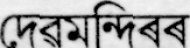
দেৱমন্দিৰৰ
